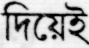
দিয়েই
